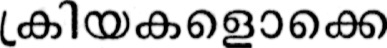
ക്രിയകളൊക്കെ
